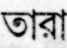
তারা
